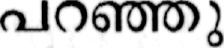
പറഞ്ഞു
